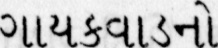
ગાયકવાડનો
